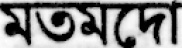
মতমদো
